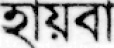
হায়বা
